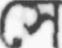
সে
